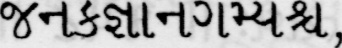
જનકજ્ઞાનગમ્યશ્વ,
